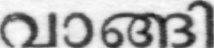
വാങ്ങി
